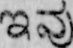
ಇವು
